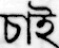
চাই
